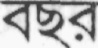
বছর
